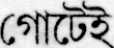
গোটেই
